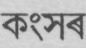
কংসৰ
